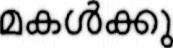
മകള്‍ക്കു
